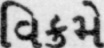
વિક્રમે
